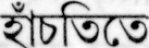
হাঁচতিতে
